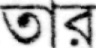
তার
